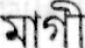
মাগী
